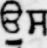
ਉਸ
